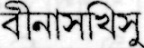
বীনাসখিসু
